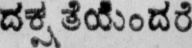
ದಕ್ಷತೆಯೆಂದರೆ
